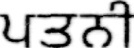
ਪਤਨੀ
